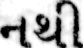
નથી
